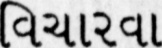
વિચારવા
